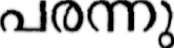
പരന്നു
